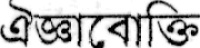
ঐজ্ঞাবোক্তি
